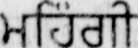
ਮਹਿੰਗੀ
